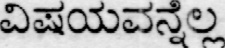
ವಿಷಯವನ್ನೆಲ್ಲ
